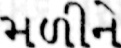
મળીને
